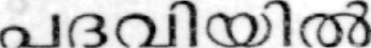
പദവിയില്‍
